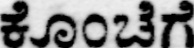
ಕೊಂಚೆಗೆ
